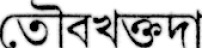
তৌবখক্তদা
